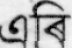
এৰি
